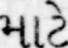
માટે
